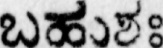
ಬಹುಶಃ
